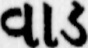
વાડ
